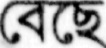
বেছে
